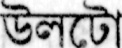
উলটো
